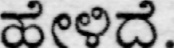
ಹೇಳಿದೆ.
